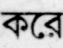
করে
